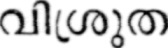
വിശ്രുത
